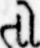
તો
